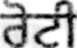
ਰੋਟੀ
